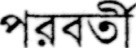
পরবর্তী
